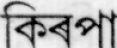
কিৰপা
